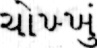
ચોખ્ખું
